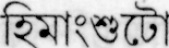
হিমাংশুটো
